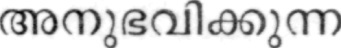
അനുഭവിക്കുന്ന
